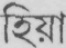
হিয়া
